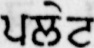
ਪਲੇਟ
